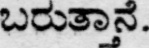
ಬರುತ್ತಾನೆ.
